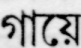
গায়ে
